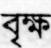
বৃক্ষ
